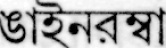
ঙাইনরম্বা
